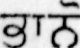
ਭਾਨੋ
